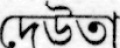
দেউতা
